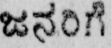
ಜನರಿಗೆ
